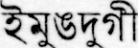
ইমুঙদুগী
